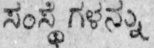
ಸಂಸ್ಥೆಗಳನ್ನು
